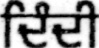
ਦਿੰਦੀ
